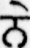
ਨੇ
